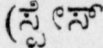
(ಸ್ಪೇಸ್
